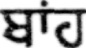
ਬਾਂਹ
